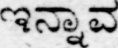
ಇನ್ನಾವ
